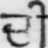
ਦੀ
